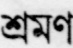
শ্রমণ
